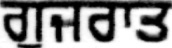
ਗੁਜਰਾਤ
